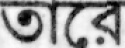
তারে
